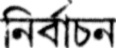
নির্বাচন
